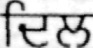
ਦਿਲ
